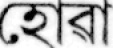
হোৱা
